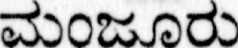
ಮಂಜೂರು
